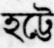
হট্টে
